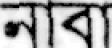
নাবা
